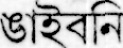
ঙাইবনি
